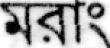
মরাং
